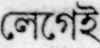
লেগেই
